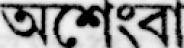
অশেংবা
